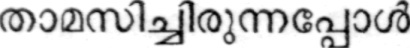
താമസിച്ചിരുന്നപ്പോള്‍
